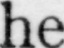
he
